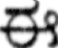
ಈ
